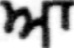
ਆ
